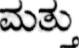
ಮತ್ತು
